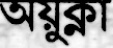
অয়ুক্না
